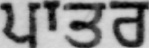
ਪਾਤਰ
